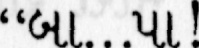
"બા...પા!
